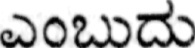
ಎಂಬುದು
